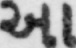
આ
